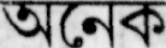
অনেক
